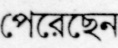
পেরেছেন
